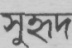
সুহৃদ
